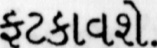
ફટકાવશે.
